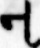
ન
